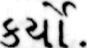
કર્યો.
